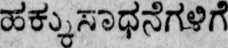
ಹಕ್ಕುಸಾಧನೆಗಳಿಗೆ
